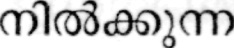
നില്‍ക്കുന്ന
